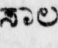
ಸಾಲ
